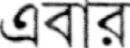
এবার
